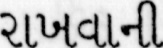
રાખવાની
